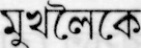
মুখলৈকে
